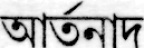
আর্তনাদ
